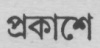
প্ৰকাশে
